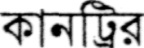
কানট্রির
